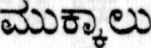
ಮುಕ್ಕಾಲು
